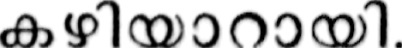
കഴിയാറായി.
